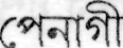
পেনাগী
